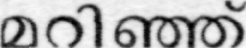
മറിഞ്ഞ്
